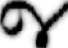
જ
